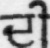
ਦੀ
